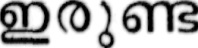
ഇരുണ്ട
